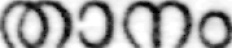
താനം
